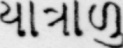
યાત્રાળુ
